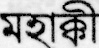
মহাক্কী
